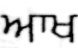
ਆਖ
